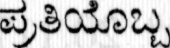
ಪ್ರತಿಯೊಬ್ಬ
